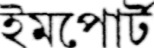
ইমপোর্ট
